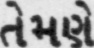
તેમણે
